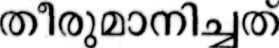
തീരുമാനിച്ചത്
